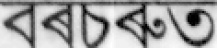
বৰচৰুত
